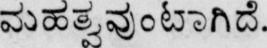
ಮಹತ್ವವುಂಟಾಗಿದೆ.
